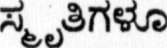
ಸ್ಮ್ರತಿಗಳೂ
